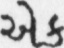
એક
